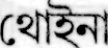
থোইনা
